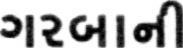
ગરબાની
